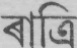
ৰাত্ৰি
